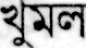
খুমল
